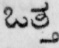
ಒತ್ತ
